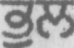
ਭੁਲ
